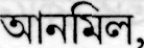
আনমিল,
